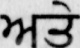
ਅਤੇ
